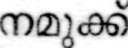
നമുക്ക്
